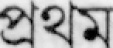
প্ৰথম
